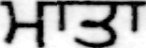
ਮਾਤਾ
